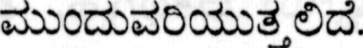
ಮುಂದುವರಿಯುತ್ತಲಿದೆ.
